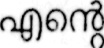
എന്റെ
